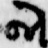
જો
